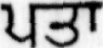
ਪਤਾ
